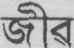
জীৱ
